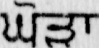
ਘੋੜਾ
